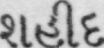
શહીદ
